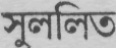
সুললিত
